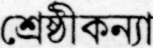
শ্রেষ্ঠীকন্যা
